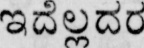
ಇದೆಲ್ಲದರ
